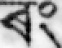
ৰং
